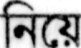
নিয়ে
